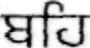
ਬਹਿ
